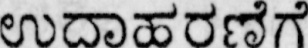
ಉದಾಹರಣೆಗೆ
